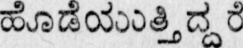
ಹೊಡೆಯುತ್ತಿದ್ದರೆ
